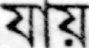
যায়
